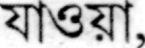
যাওয়া,
